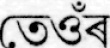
তেওঁৰ
